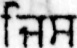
ਜਿਸ
